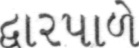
દ્વારપાળે
